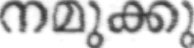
നമുക്കു
